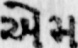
એમ
